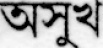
অসুখ
